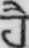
ਹੈ
